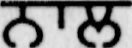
ਨਾਲ
